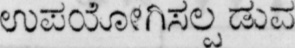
ಉಪಯೋಗಿಸಲ್ಪಡುವ
